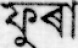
ফুৰা
